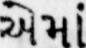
એમાં
